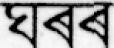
ঘৰৰ
